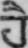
ਹੈ
